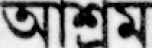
আশ্রম
